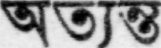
অত্যন্ত
